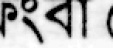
ফংবা
